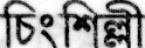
চিংশিল্লী
